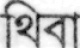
থিবা
